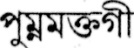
পুম্নমক্তগী
